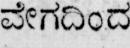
ವೇಗದಿಂದ
